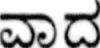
ವಾದ
